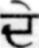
ਦੇ
